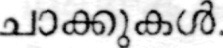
ചാക്കുകള്‍.
